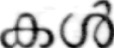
കള്‍
